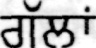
ਗੱਲਾਂ
